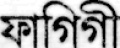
ফাগিগী
